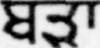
ਬੜਾ
